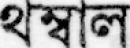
থম্বাল
